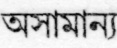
অসামান্য
